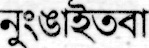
নুংঙাইতবা
